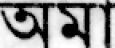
অমা
